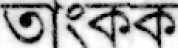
তংকক
